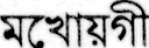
মখোয়গী
